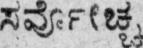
ಸರ್ವೋಚ್ಚ
